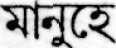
মানুহে
